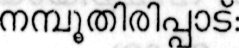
നമ്പൂതിരിപ്പാട്:
